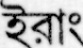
ইরাং
